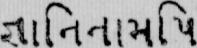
જ્ઞાનિનામષિ
